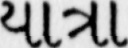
યાત્રા
